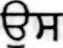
ਉਸ
